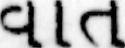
વાત
